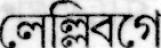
লেল্লিবগে
